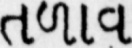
તળાવ
